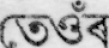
তেওঁৰ
